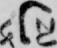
દ્રષ્ટિ
